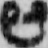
ಆ
